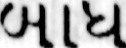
બાધ
